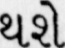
થશે
